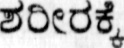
ಶರೀರಕ್ಕೆ
